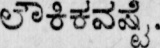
ಲೌಕಿಕವಷ್ಟೆ.
